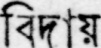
বিদায়
